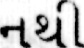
નથી
